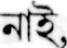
নাই,
